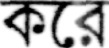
করে
